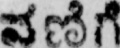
ವಣಿಗೆ
